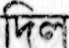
দিল
